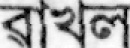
ৱাখল
